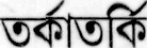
তর্কাতর্কি
